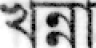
খন্না
